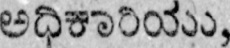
ಅಧಿಕಾರಿಯು,
